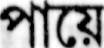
পায়ে
